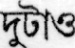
দুটাও
